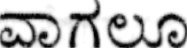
ವಾಗಲೂ
